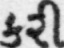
કરી
